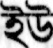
ইউ
